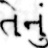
તેનું
